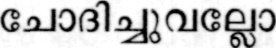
ചോദിച്ചുവല്ലോ
